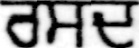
ਰਸਦ
